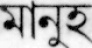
মানুহ
